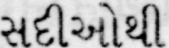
સદીઓથી
